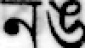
নঙ
